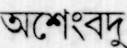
অশেংবদু
